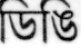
ডিঙি
